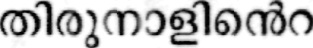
തിരുനാളിന്റെ
